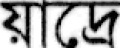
য়াদ্রে
